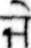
ਜੇ
